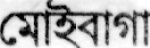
মোইবাগা
